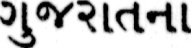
ગુજરાતના
